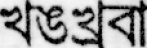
খঙখ্রবা
